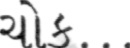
ચોક...
